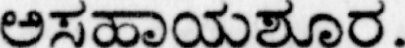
ಅಸಹಾಯಶೂರ.
